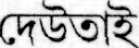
দেউতাই
